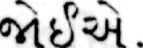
જોઈએ.
